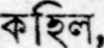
কহিল,
